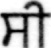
ਸੀ
